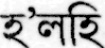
হ'লহি
